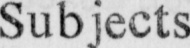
Subjects.
